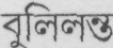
বুলিলন্ত
